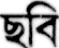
ছবি
